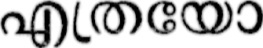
എത്രയോ
